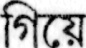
গিয়ে
